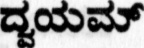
ಧ್ವಯಮ್
